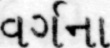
વર્ગના
